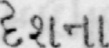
દેશના
